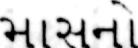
માસનો
